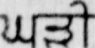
ਘੜੀ
